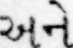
અને
